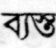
ব্যস্ত
